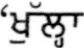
'ਖੁੱਲ੍ਹਾ
